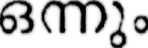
ഒന്നും
